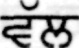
ਵੱਲ
